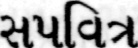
સપવિત્ર
